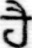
ਹੈ
